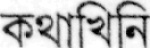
কথাখিনি
